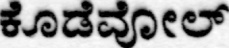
ಕೊಡೆವೋಲ್
